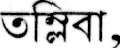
তম্লিবা,
